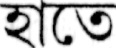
হাতে
